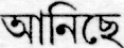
আনিছে
